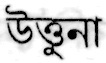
উত্তুনা
